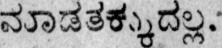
ಮಾಡತಕ್ಕುದಲ್ಲ.
